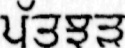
ਪੱਤਝੜ
